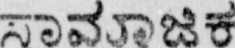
ಸಾಮಾಜಿಕ
